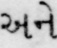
અને
